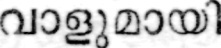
വാളുമായി
